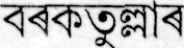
বৰকতুল্লাৰ
